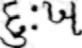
દુઃખ
